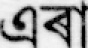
এৰা
